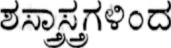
ಶಸ್ತ್ರಾಸ್ತ್ರಗಳಿಂದ
